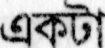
একটা
